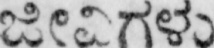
ಜೀವಿಗಳು
